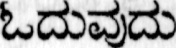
ಓದುವುದು
